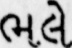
ભલે
